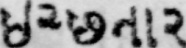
ઇચ્છનાર
